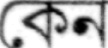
কেন
